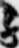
કે
